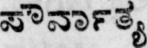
ಪೌರ್ವಾತ್ಯ
